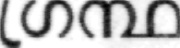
ഗ്രന്ഥ
